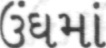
ઉંઘમાં
